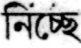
নিচ্ছে
